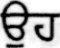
ਉਹ
